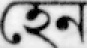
হেন
